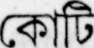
কোটি
